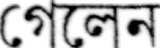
গেলেন
